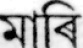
মাৰি
